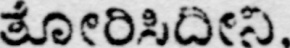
ತೋರಿಸಿದೀನಿ.
